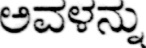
ಅವಳನ್ನು
